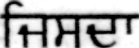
ਜਿਸਦਾ
